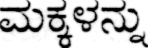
ಮಕ್ಕಳನ್ನು
